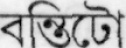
বন্তিটো
